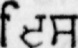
ਇਸ
